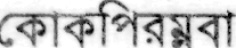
কোকপিরম্নবা
